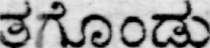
ತಗೊಂಡು
